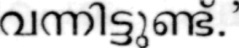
വന്നിട്ടുണ്ട്.'
